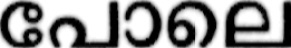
പോലെ
